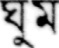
ঘুম
